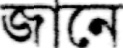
জানে
